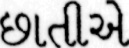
છાતીએ
